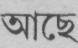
আছে
